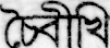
চৈবীখি
